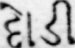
દોડી
